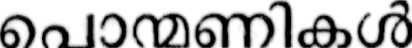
പൊന്മണികള്‍
